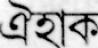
ঐহাক
